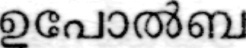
ഉപോല്‍ബ
